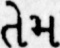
તેમ
